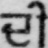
ਦੀ
